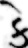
કે
